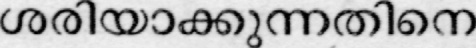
ശരിയാക്കുന്നതിനെ
